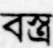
বস্ত্র
